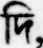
দি,
